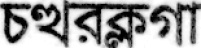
চত্থরক্লগা
